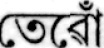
তেৱোঁ
